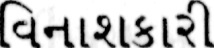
વિનાશકારી
